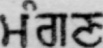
ਮੰਗਣ
